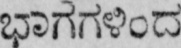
ಭಾಗಗಳಿಂದ
